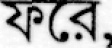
ফরে,
